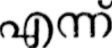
എന്ന്
